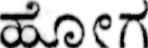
ಹೋಗ
